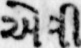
એવી
